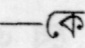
–কে
